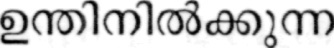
ഉന്തിനില്‍ക്കുന്ന
